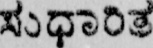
ಸುಧಾರಿತ
